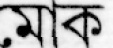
মোক
